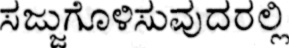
ಸಜ್ಜುಗೊಳಿಸುವುದರಲ್ಲಿ
